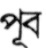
পূব
